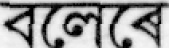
বলেৰে
